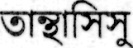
তান্থাসিসু
